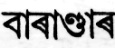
বাৰাণ্ডাৰ
